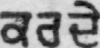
ਕਰਦੇ
